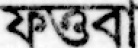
ফত্তবা
